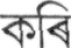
কৰি
